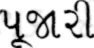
પૂજારી
